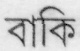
বাকি
